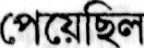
পেয়েছিল
